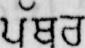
ਪੱਥਰ
